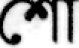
শো
